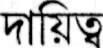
দায়িত্ব
